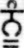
ਨੂੰ
